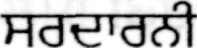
ਸਰਦਾਰਨੀ
